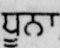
ਧੂਨਾ
